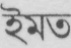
ইমত
